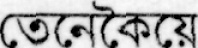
তেনেকৈয়ে
